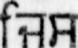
ਜਿਸ
